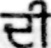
ਦੀ
